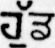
ਹੁੱਡ
